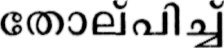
തോല്പിച്ച്
